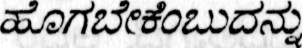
ಹೊಗಬೇಕೆಂಬುದನ್ನು
